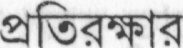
প্রতিরক্ষার
